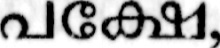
പക്ഷേ,
